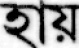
হায়
